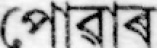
পোৱাৰ
